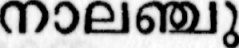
നാലഞ്ചു
